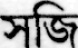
সজি
